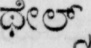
ಥೇಲ್ಸ್
